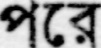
পরে
